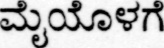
ಮೈಯೊಳಗೆ
